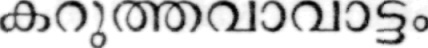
കറുത്തവാവാട്ടം
